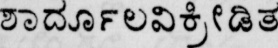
ಶಾರ್ದೂಲವಿಕ್ರೀಡಿತ
